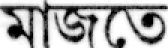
মাজতে
